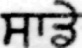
ਸਾਡੇ
